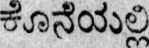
ಕೊನೆಯಲ್ಲಿ
